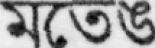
মতেঙ
